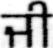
ਜੀ
